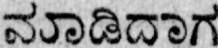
ಮಾಡಿದಾಗ
